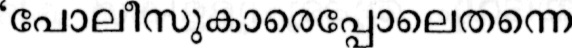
'പോലീസുകാരെപ്പോലെതന്നെ
